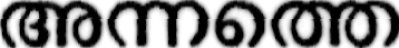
അന്നത്തെ
